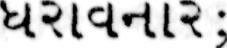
ધરાવનાર;
